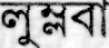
লুম্লবা
